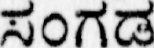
ಸಂಗಡ
